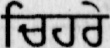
ਚਿਹਰੇ
